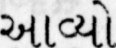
આવ્યો
